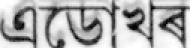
এডোখৰ
